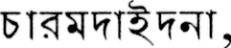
চারমদাইদনা,
